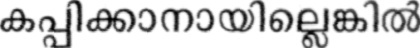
കപ്പിക്കാനായില്ലെങ്കില്‍
